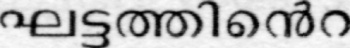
ഘട്ടത്തിന്റെ
